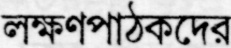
লক্ষণপাঠকদের
